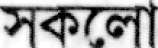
সকলো
